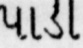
પાડી
